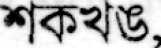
শকখঙ,
